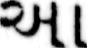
આ
